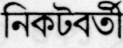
নিকটবর্তী
